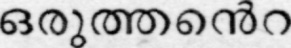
ഒരുത്തന്റെ
